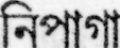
নিপাগা
